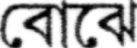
বোঝে
